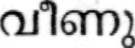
വീണു
